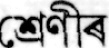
শ্রেণীৰ
